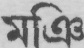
মঞি
